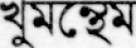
খুমন্থেম
